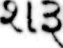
શરૂ
